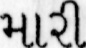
મારી
